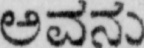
ಅವನು
